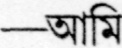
–আমি
